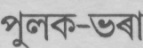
পুলক-ভৰা
